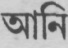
আনি
